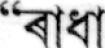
"ৰাধা
